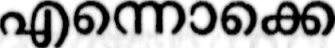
എന്നൊക്കെ
